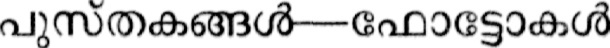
പുസ്തകങ്ങള്‍-ഫോട്ടോകള്‍
